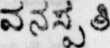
ವನಸ್ಪತಿ
